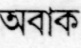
অবাক
